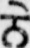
ਨੇ
